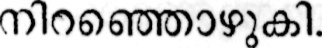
നിറഞ്ഞൊഴുകി.
